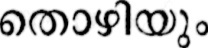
തൊഴിയും
